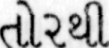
તોરથી
